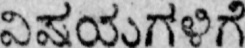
ವಿಷಯಗಳಿಗೆ
